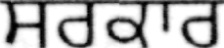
ਸਰਕਾਰ
